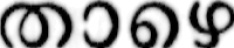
താഴെ
